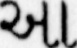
આ
